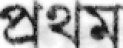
প্রথম
